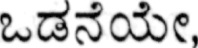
ಒಡನೆಯೇ,
